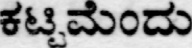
ಕಟ್ಟಿಮೆಂದು
